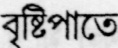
বৃষ্টিপাতে
